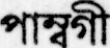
পাম্বগী
